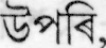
উপৰি,
